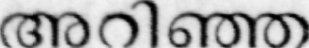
അറിഞ്ഞ
